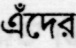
এঁদের
